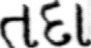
તદા
